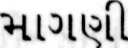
માગણી
